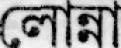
লোন্না
